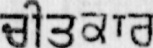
ਚੀਤਕਾਰ
